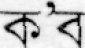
ক'ব
